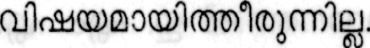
വിഷയമായിത്തീരുന്നില്ല.
